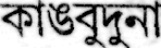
কাঙবুদুনা
